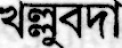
খল্লুবদা
